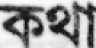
কথা
